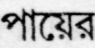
পায়ের
